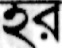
হর
